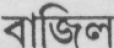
বাজিল
